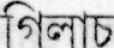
গিলাচ
